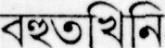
বহুতখিনি
